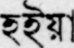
হইয়া
